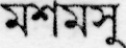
মশমসু
